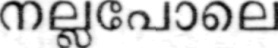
നല്ലപോലെ
